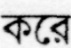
করে
